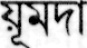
য়ূমদা
